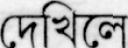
দেখিলে
